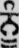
ਨੂੰ
